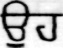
ਉਹ
